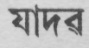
যাদৱ
